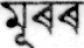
মূৰৰ
